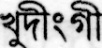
খুদীংগী
